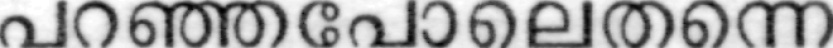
പറഞ്ഞപോലെതന്നെ
